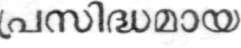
പ്രസിദ്ധമായ
